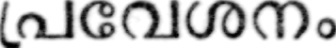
പ്രവേശനം
